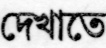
দেখাতে
